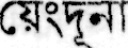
য়েংদূনা
